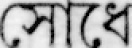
সোধে
